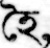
হৈ,
